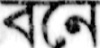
বনে
